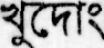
খুদোং
